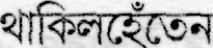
থাকিলহেঁতেন
